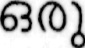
ഒരു
